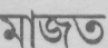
মাজত
